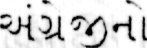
અંગ્રેજીનો
